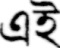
এই
